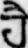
ਹੈ
